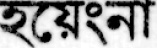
হয়েংনা
